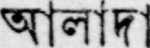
আলাদা
